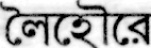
লৈহৌরে
